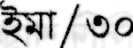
ইমা/৩০
